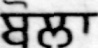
ਬੋਲਾ
